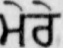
ਮੇਰੇ
